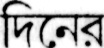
দিনের
